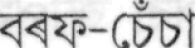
বৰফ-চেঁচা
